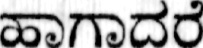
ಹಾಗಾದರೆ
